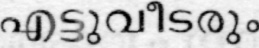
എട്ടുവീടരും
